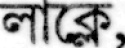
লাক্লে,
